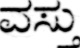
ವಸ್ತು
